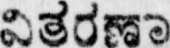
ವಿತರಣಾ
